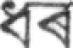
ধৰ
